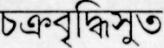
চক্রবৃদ্ধিসুত
